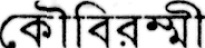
কৌবিরম্মী
